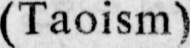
(Taoism)
